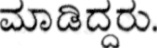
ಮಾಡಿದ್ದರು.
